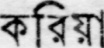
করিয়া
